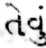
તેવું
